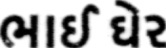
ભાઈઘેર
